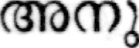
അനു
